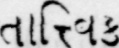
તાત્ત્વિક
